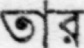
তার
